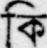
কি
